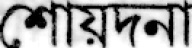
শোয়দনা
